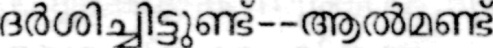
ദര്‍ശിച്ചിട്ടുണ്ട്--ആല്‍മണ്ട്
